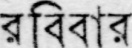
রবিবার
